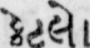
કેટલો
